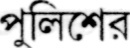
পুলিশের
